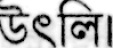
উৎলি।
